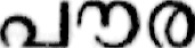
പൌര
